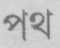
পথ
